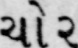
ચોર
